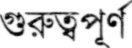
গুরুত্বপূর্ণ
